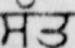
ਸੱਤ
